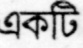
একটি
